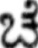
ಚೆ
